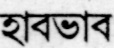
হাবভাব
